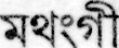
মথংগী
